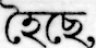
হৈছে,
